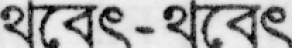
থবেৎ-থবেৎ
